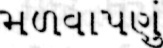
મળવાપણું
